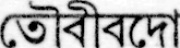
তৌবীবদো
